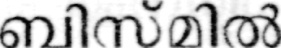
ബിസ്മില്‍
